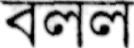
বলল
